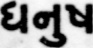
ધનુષ
